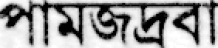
পামজদ্রবা
